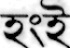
হংই
